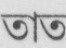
তাত
